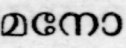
മനോ
